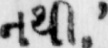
નથી.
